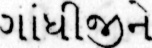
ગાંધીજીને
